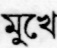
মুখে
